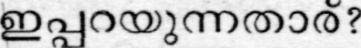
ഇപ്പറയുന്നതാര്?
